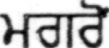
ਮਗਰੋਂ
